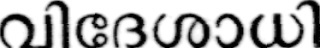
വിദേശാധി
